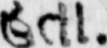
હતા.
